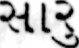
સારુ
